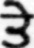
ਤੇ
